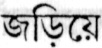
জড়িয়ে
